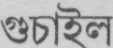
গুচাইল
